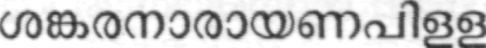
ശങ്കരനാരായണപിളള
